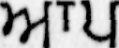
ਆਪ
